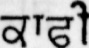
ਕਾਫੀ
